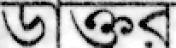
ডাক্তর
